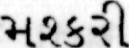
મશ્કરી
